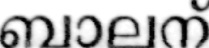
ബാലന്
